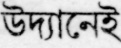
উদ্যানেই
